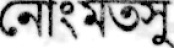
নোংমতসু
